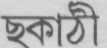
ছকাঠী
